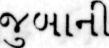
જુબાની
